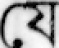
যে
